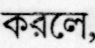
করলে,
